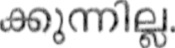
ക്കുന്നില്ല.
